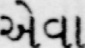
એવા
